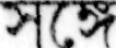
সঙ্গে
